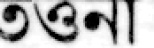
তত্তনা
